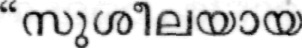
"സുശീലയായ
